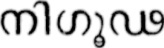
നിഗൂഢ
